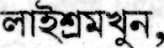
লাইশ্রমখুন,
